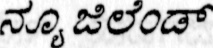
ನ್ಯೂಜಿಲೆಂಡ್
